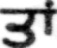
ਤਾਂ
